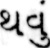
થવું
